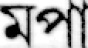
মপা
